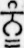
ਨੂੰ
